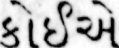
કોઇએ
